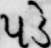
પડે
